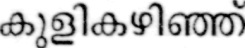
കുളികഴിഞ്ഞ്
